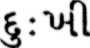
દુઃખી
